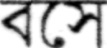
বসে
